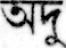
অদু
